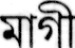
মাগী
